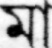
মা
